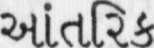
આંતરિક
